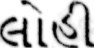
લોહી
